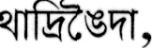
থাদ্রিঙৈদা,
